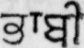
ਭਾਬੀ
